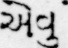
એવું
